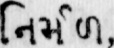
નિર્મળ,
